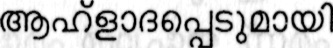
ആഹ്ളാദപ്പെടുമായി
